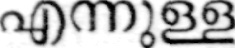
എന്നുള്ള
